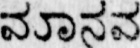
ಮಾನವ
